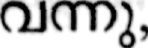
വന്നു,
